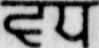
ਵਧ
